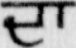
ਦਾ
